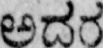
ಅದರ
